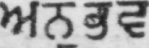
ਅਨੁਭਵ
